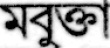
মবুক্তা
